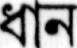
ধান
